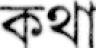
কথা
